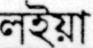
লইয়া
